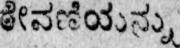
ಠೇವಣಿಯನ್ನು
